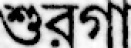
শুরগা
